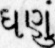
ઘણું
